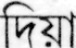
দিয়া
